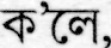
ক'লে,
